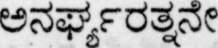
ಅನರ್ಘ್ಯರತ್ನನೇ
